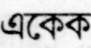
একেক
